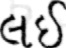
લઈ
